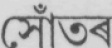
সোঁতৰ
